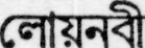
লোয়নবী
